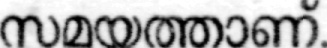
സമയത്താണ്.
